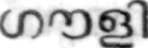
ഗൌളി
